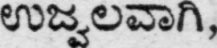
ಉಜ್ವಲವಾಗಿ,
